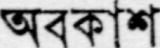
অবকাশ
